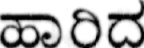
ಹಾರಿದ
